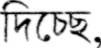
দিচ্ছে,
